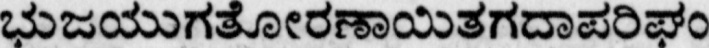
ಭುಜಯುಗತೋರಣಾಯಿತಗದಾಪರಿಘಂ
